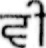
ਵੀ
